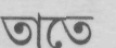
তাতে
